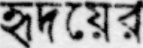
হৃদয়ের
